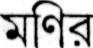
মণির
